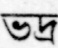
ভদ্র
